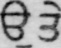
ਉਤੇ
